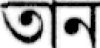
তান
